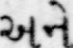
અને
